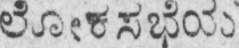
ಲೋಕಸಭೆಯ
